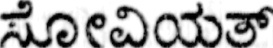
ಸೋವಿಯತ್
